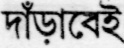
দাঁড়াবেই
